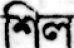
শিল
